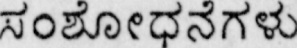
ಸಂಶೋಧನೆಗಳು
